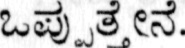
ಒಪ್ಪುತ್ತೇನೆ.
